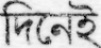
দিনেই
